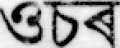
ওচৰ
